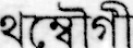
থম্বৌগী
